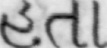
હતા
